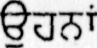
ਉਹਨਾਂ
